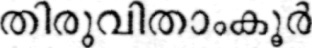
തിരുവിതാംകൂര്‍
